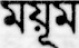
ময়ুম
